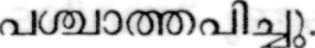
പശ്ചാത്തപിച്ചു.
